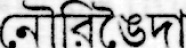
নৌরিঙৈদা
